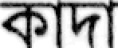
কাদা
